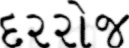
દરરોજ
